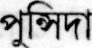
পুন্সিদা
